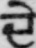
ਦੇ
